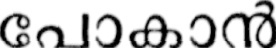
പോകാന്‍
